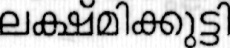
ലക്ഷ്മിക്കുട്ടി
